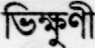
ভিক্ষুণী
